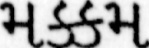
મક્કમ
